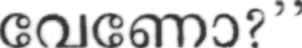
വേണോ?"
